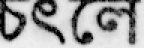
চৎলে
